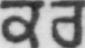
ਕਰ
